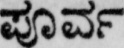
ಪೂರ್ವ
